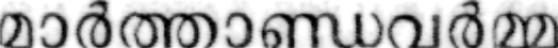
മാര്‍ത്താണ്ഡവര്‍മ്മ
